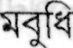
মবুধি
